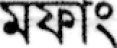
মফাং
